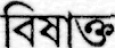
বিষাক্ত
